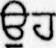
ਉਹ
